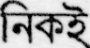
নিকই
